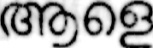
ആളെ
